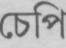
চেপি
